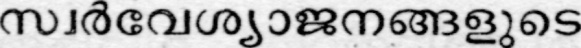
സ്വര്‍വേശ്യാജനങ്ങളുടെ
